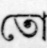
তো
